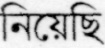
নিয়েছি
